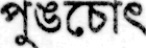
পুঙচোৎ
